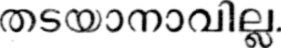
തടയാനാവില്ല.
